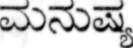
ಮನುಷ್ಯ
